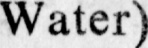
Water)
